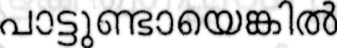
പാട്ടുണ്ടായെങ്കില്‍
